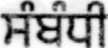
ਸੰਬੰਧੀ
